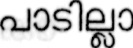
പാടില്ലാ
